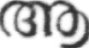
ആ
